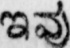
ಇವು
